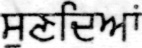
ਸੁਣਦਿਆਂ
